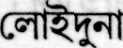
লোইদুনা
